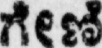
ಗೇಣಿ
